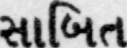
સાબિત
